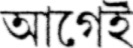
আগেই
